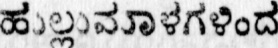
ಹುಲ್ಲುಮಾಳಗಳಿಂದ
